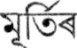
মূর্তিৰ
